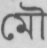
মৌ
